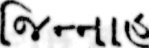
જિન્નાહ
